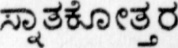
ಸ್ನಾತಕೋತ್ತರ
